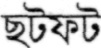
ছটফট
